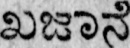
ಖಜಾನೆ
